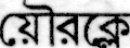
য়ৌরক্লে
